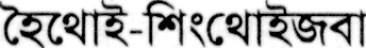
হৈথোই-শিংথোইজবা
